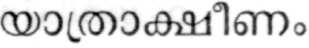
യാത്രാക്ഷീണം
